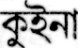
কুইনা
